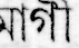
মাগী
